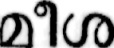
മീശ
